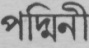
পদ্মিনী
